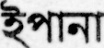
ইপানা
